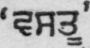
'ਵਸਤੂ'
